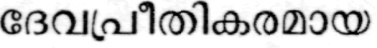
ദേവപ്രീതികരമായ
